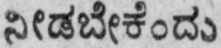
ನೀಡಬೇಕೆಂದು
